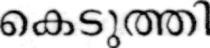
കെടുത്തി
